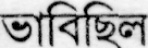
ভাবিছিল
